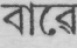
বাৱে
